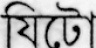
যিটো
